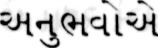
અનુભવોએ
